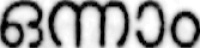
ഒന്നാം
